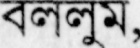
বললুম,
